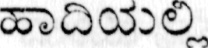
ಹಾದಿಯಲ್ಲಿ
